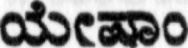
ಯೇಷಾಂ
